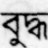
বুদ্ধ
